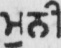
ਮੁਨੀ
